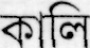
কালি
